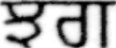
ਝਗ
